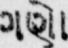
ગણો
